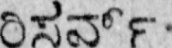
ರಿಸರ್ವ್
